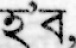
হ'ব,
